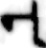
ન
